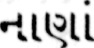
નાણાં
